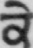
ਕੇ
